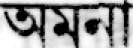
অমনা
